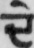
ਦੇ
